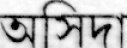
অসিদা
